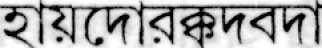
হায়দোরক্কদবদা
